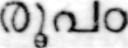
രൂപം
